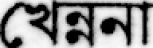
খেন্ননা
